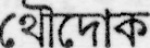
থৌদোক
